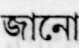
জানো
